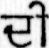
ਦੀ
